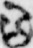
છે
